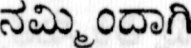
ನಮ್ಮಿಂದಾಗಿ
